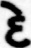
દે
